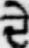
ਦੇ
